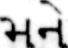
મને
